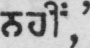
ਨਹੀਂ,'
